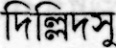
দিল্লিদসু
